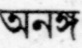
অনঙ্গ
